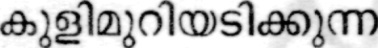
കുളിമുറിയടിക്കുന്ന
